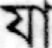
যা
